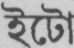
ইটো
